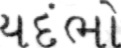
યદંભો
